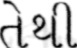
તેથી
